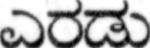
ಎರಡು
